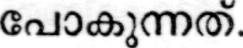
പോകുന്നത്.
